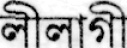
লীলাগী
